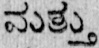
ಮತ್ತು
